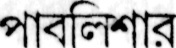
পাবলিশার
